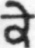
ਕੇ
